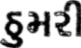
ઠુમરી
